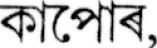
কাপোৰ,
